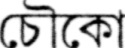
চৌকো
